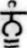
ਨੂੰ
